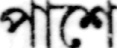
পাশে
